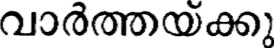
വാര്‍ത്തയ്ക്കു
